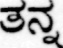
ತನ್ನ
